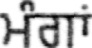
ਮੰਗਾਂ
